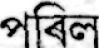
পৰিল
